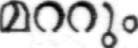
മററും
